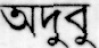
অদুবু
